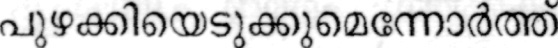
പുഴക്കിയെടുക്കുമെന്നോര്‍ത്ത്
